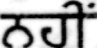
ਨਹੀਂ
